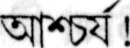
আশ্চর্য!
